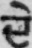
ਦੇ
